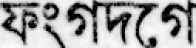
ফংগদগে
